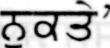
ਨੁਕਤੇ'
